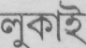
লুকাই
